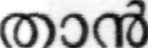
താന്‍
